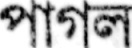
পাগল
